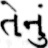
તેનું
